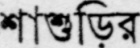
শাশুড়ির
